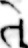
તે
